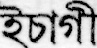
ইচাগী
